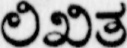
ಲಿಖಿತ
